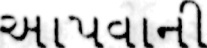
આપવાની
